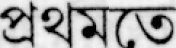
প্রথমতে
